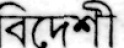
বিদেশী
